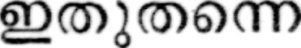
ഇതുതന്നെ
